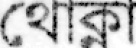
থোক্না
